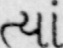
ત્યાં
